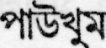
পাউখুম
